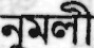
নুমলী
